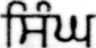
ਸਿੰਘ
